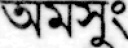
অমসুং
